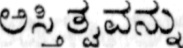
ಅಸ್ತಿತ್ವವನ್ನು
